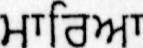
ਮਾਰਿਆ
